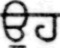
ਉਹ
